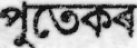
পুতেকৰ
